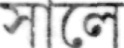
সালে
